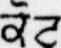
ਕੋਟ
